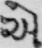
એ
